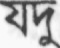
যদু
